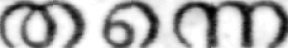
തന്നെ
